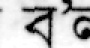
ব'ল
